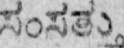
ಸಂಸತ್ತು
